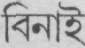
বিনাই
